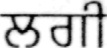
ਲਗੀ
